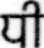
ਧੀ
